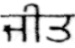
ਜੀਤ
